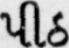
પીઠ
